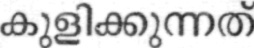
കുളിക്കുന്നത്
